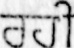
ਰਹੀ
